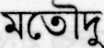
মতৌদু
